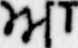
ਆ
